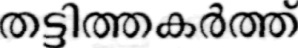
തട്ടിത്തകര്‍ത്ത്
